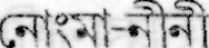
নোংমা-নীনী
